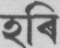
হৰি
